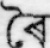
ৰৈ
